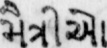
મૈત્રીઓ
